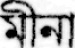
মীনা
